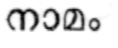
നാമം
